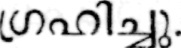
ഗ്രഹിച്ചു.
